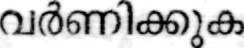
വര്‍ണിക്കുക
